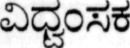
ವಿಧ್ವಂಸಕ
